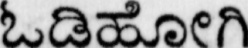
ಓಡಿಹೋಗಿ
